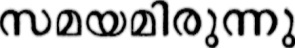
സമയമിരുന്നു
